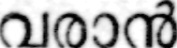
വരാന്‍
